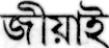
জীয়াই
